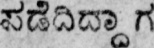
ಪಡೆದಿದ್ದಾಗ
